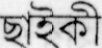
ছাইকী
